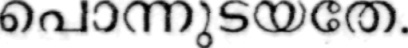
പൊന്നുടയതേ.
